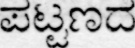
ಪಟ್ಟಣದ
